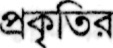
প্রকৃতির
